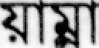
য়াম্না
